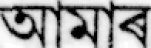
আমাৰ
